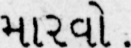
મારવો.
